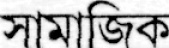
সামাজিক
